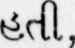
હતી,
